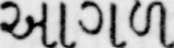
આગળ
